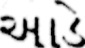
આડે
